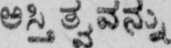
ಅಸ್ತಿತ್ವವನ್ನು
